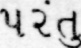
પરંતુ
